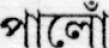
পালোঁ
